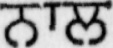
ਨਾਲ
